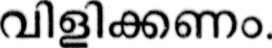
വിളിക്കണം.
